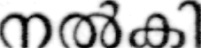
നല്‍കി
